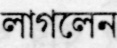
লাগলেন
